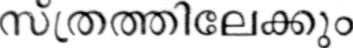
സ്ത്രത്തിലേക്കും
